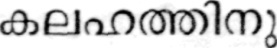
കലഹത്തിനു
